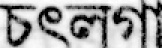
চৎলগা
